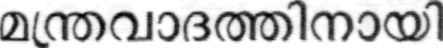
മന്ത്രവാദത്തിനായി
